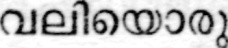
വലിയൊരു
